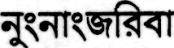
নুংনাংজরিবা
